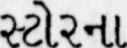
સ્ટોરના
